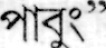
পাবুং”
